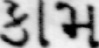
કામ
